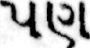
પણ
